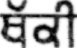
ਥੱਕੀ
